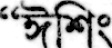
“ঈশিং
